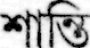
শান্তি
